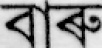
বাৰু
